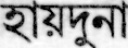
হায়দুনা
